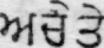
ਅਚੇਤੇ
